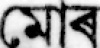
মোৰ
